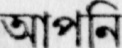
আপনি
